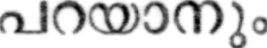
പറയാനും
